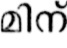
മിന്
